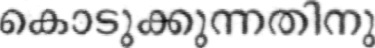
കൊടുക്കുന്നതിനു
